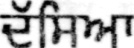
ਦੱਸਿਆ
